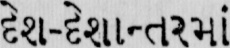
દેશ-દેશાન્તરમાં
